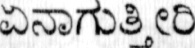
ಏನಾಗುತ್ತೀರಿ
